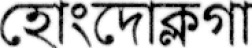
হোংদোক্লগা
